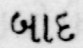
બાદ
